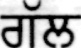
ਗੱਲ
